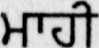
ਮਾਹੀ
